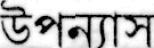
উপন্যাস
